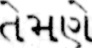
તેમણે
